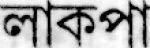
লাকপা
